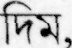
দিম,
